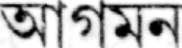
আগমন
